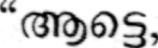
“ആട്ടെ,
